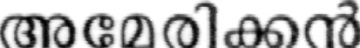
അമേരിക്കന്‍
